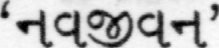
'નવજીવન'
